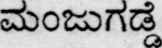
ಮಂಜುಗಡ್ಡೆ
